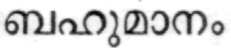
ബഹുമാനം
